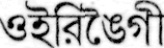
ওইরিঙৈগী
